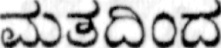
ಮತದಿಂದ
